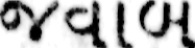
જવાબ
